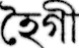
হৈগী
